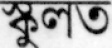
স্কুলত
